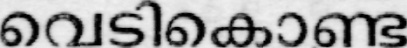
വെടികൊണ്ട
